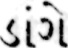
ડાંગે
